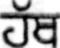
ਹੱਥ
